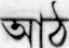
আঠ
